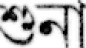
শুনা
